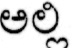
ಅಲ್ಲಿ
